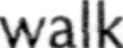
walk
